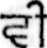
ਵੀ
